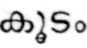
കൂടം
